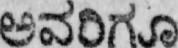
ಅವರಿಗೂ
